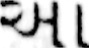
આ
